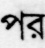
পর
